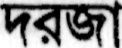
দরজা
